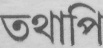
তথাপি
